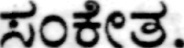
ಸಂಕೇತ.
